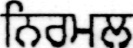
ਨਿਰਮਲ
